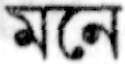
মনে
